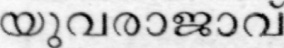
യുവരാജാവ്
